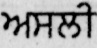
ਅਸਲੀ
